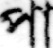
পা
